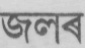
জলৰ
